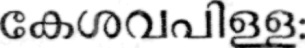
കേശവപിള്ള:
